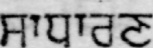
ਸਾਧਾਰਣ
